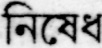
নিষেধ
